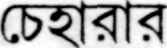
চেহারার
